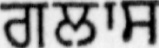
ਗਲਾਸ
